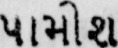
પામીશ
